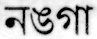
নঙগা
